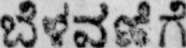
ಬೆಳವಣಿಗೆ
